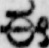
ಈ
